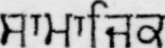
ਸਾਮਾਜਿਕ
